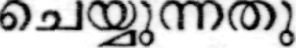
ചെയ്യുന്നതു
